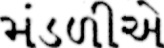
મંડળીએ
